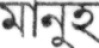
মানুহ
